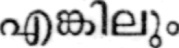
എങ്കിലും
